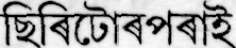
ছিৰিটোৰপৰাই
